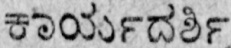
ಕಾರ್ಯದರ್ಶಿ
